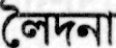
লৈদনা
